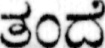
ತಂದೆ
